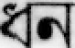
ধন
